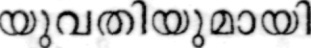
യുവതിയുമായി
